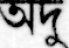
অদু
